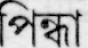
পিন্ধা
